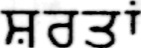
ਸ਼ਰਤਾਂ
